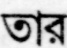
তার
